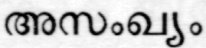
അസംഖ്യം
